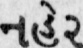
નહેર
